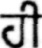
ਹੀ
